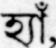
হ্যাঁ,
